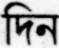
দিন
